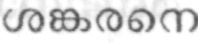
ശങ്കരനെ
